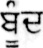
ਬੂੰਦ
